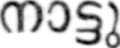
നാട്ടു
